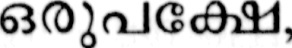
ഒരുപക്ഷേ,
